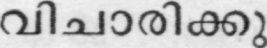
വിചാരിക്കു
